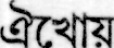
ঐখোয়
